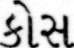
કોસ
